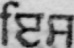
ਇਸ
